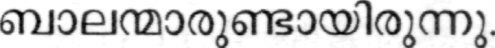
ബാലന്മാരുണ്ടായിരുന്നു.
